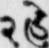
રહે
